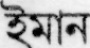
ইমান
